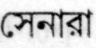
সেনারা
